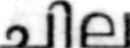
ചില
